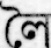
লৈ
